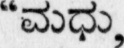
“ಮಧು,
